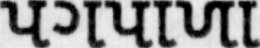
પગપાળા
